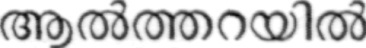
ആല്‍ത്തറയില്‍
